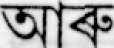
আৰু
